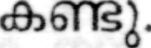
കണ്ടു.
